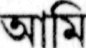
আমি
